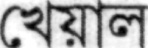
খেয়াল
